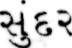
સુંદર
